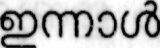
ഇന്നാള്‍
